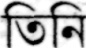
তিনি
